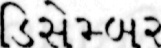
ડિસેમ્બર
